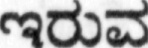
ಇರುವ
